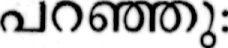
പറഞ്ഞു:
